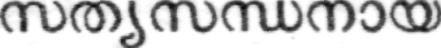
സത്യസന്ധനായ
